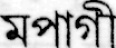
মপাগী
